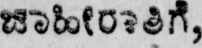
ಜಾಹೀರಾತಿಗೆ,
